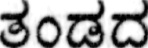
ತಂಡದ
